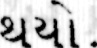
થયો.
